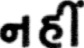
નહીં
